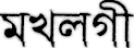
মখলগী
